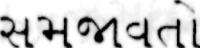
સમજાવતો
